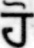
ਹੋ
